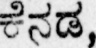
ಕೆನಡ,
